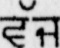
ਵੱਜ
